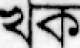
খক
